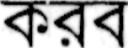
করব
